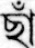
ছাঁ
